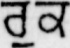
ਰੁਕ
